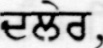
ਦਲੇਰ,
